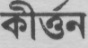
কীৰ্ত্তন
